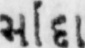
માંદા
